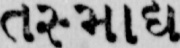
તસ્માધ
